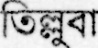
তিল্লুবা
